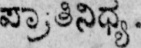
ಪ್ರಾತಿನಿಧ್ಯ.
